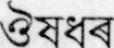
ঔষধৰ
